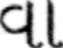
વા
